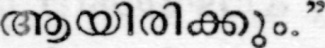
ആയിരിക്കും.”
